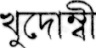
খুদোম্বী
